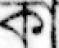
কা
